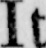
It
